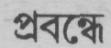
প্ৰবন্ধে
